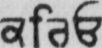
ਕਰਿਓ
